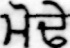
ਮੋਢੇ
